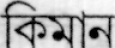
কিমান
